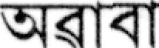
অৱাবা
